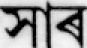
সাৰ
